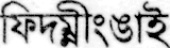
ফিদম্নীংঙাই
